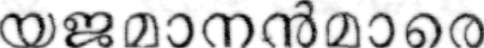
യജമാനന്‍മാരെ
